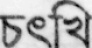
চৎখি
